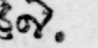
રહેજે.
